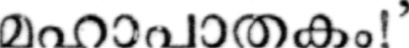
മഹാപാതകം!'
